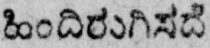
ಹಿಂದಿರುಗಿಸದೆ
